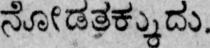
ನೋಡತಕ್ಕುದು.
